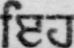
ਇਹ
